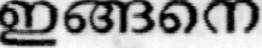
ഇങ്ങനെ
